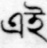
এই
